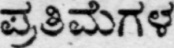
ಪ್ರತಿಮೆಗಳ
